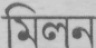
মিলন
